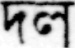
দল
